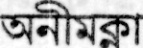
অনীমক্না
